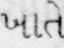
ખાતે
